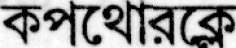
কপথোরক্লে
